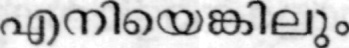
എനിയെങ്കിലും
